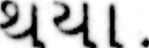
થયા.
